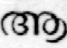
ആ
